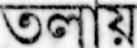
তলায়
